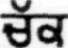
ਚੱਕ
